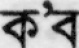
ক'ব
